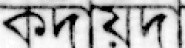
কদায়দা
